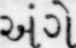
અંગે
